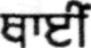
ਥਾਈਂ
